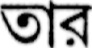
তার
